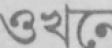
ওখনে
